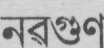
নৱগুণ
